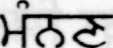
ਮੰਨਣ
